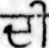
ਦੀ
